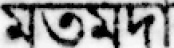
মতমদা
